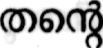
തന്റെ
